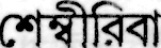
শেম্বীরিবা
